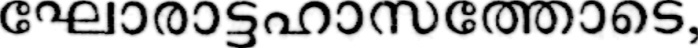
ഘോരാട്ടഹാസത്തോടെ,
